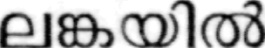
ലങ്കയില്‍
